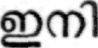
ഇനി
